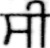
ਸੀ
